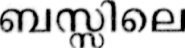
ബസ്സിലെ
